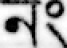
নং
